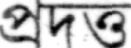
প্রদত্ত
